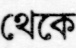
থেকে
